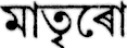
মাতৃৰো
